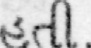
હતી.
